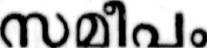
സമീപം
